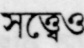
সত্ত্বেও
